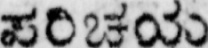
ಪರಿಚಯ
